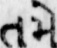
તમે
